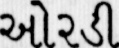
ઓરડી
